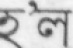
হ'ল
